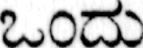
ಒಂದು
